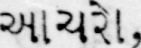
આચરો,
